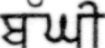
ਬੱਘੀ
